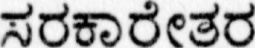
ಸರಕಾರೇತರ
